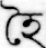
হৈ
